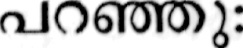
പറഞ്ഞു:
